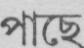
পাছে
